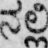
ನಲ್ಲಿ
